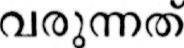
വരുന്നത്
